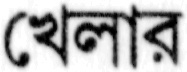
খেলার
